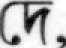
দে,
